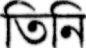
তিনি
